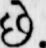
છે.
